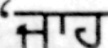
'ਜਾਹ
